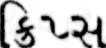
ક્રિપ્સ
